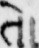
તો
